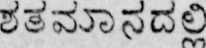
ಶತಮಾನದಲ್ಲಿ
